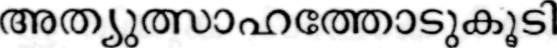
അത്യുത്സാഹത്തോടുകൂടി
